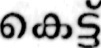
കെട്ട്
